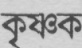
কৃষ্ণক
